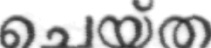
ചെയ്ത
